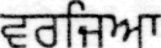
ਵਰਜਿਆ
